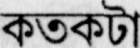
কতকটা
